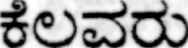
ಕೆಲವರು
